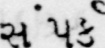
સંપર્ક
